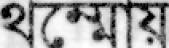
থম্মোয়
